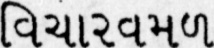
વિચારવમળ
